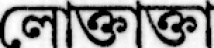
লোক্তাক্তা
